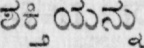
ಶಕ್ತಿಯನ್ನು
